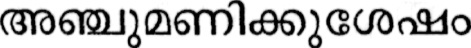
അഞ്ചുമണിക്കുശേഷം
